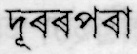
দূৰৰপৰা
